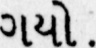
ગયો.
